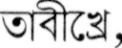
তাবীখ্রে,
